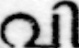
വി
